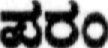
ಪರಂ
